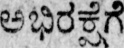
ಅಭಿರಕ್ಷೆಗೆ
